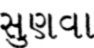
સુણવા
